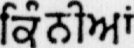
ਕਿੰਨੀਆਂ
